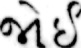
જોઈ
